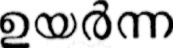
ഉയര്‍ന്ന
